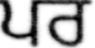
ਪਰ
